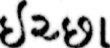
ઇચ્છા
